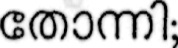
തോന്നി;
